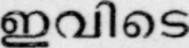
ഇവിടെ
